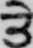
ਤੇ
